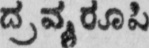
ದ್ರವ್ಯರೂಪಿ
